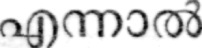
എന്നാല്‍
